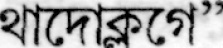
থাদোক্লগে”
